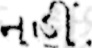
નહીં.
